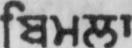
ਬਿਮਲਾ
